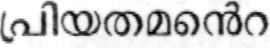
പ്രിയതമന്റെ
